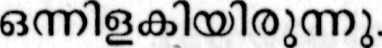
ഒന്നിളകിയിരുന്നു.
